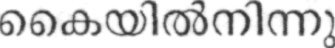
കൈയില്‍നിന്നു
